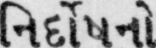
નિર્દોષનો
